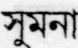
সুমনা
